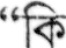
"কি
